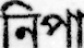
নিপা
